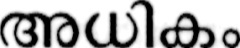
അധികം
